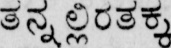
ತನ್ನಲ್ಲಿರತಕ್ಕ
